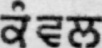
ਕੰਵਲ
